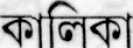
কালিকা
